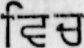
ਵਿਚ
